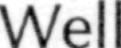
Well
